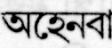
অহেনবা
